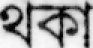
থকা
